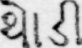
થોડી
